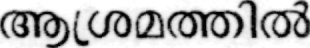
ആശ്രമത്തില്‍
